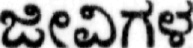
ಜೀವಿಗಳ
